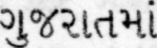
ગુજરાતમાં
